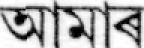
আমাৰ
